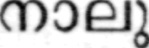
നാലു
